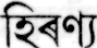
হিৰণ্য
